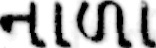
નાળા
